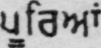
ਪੂਰਿਆਂ
